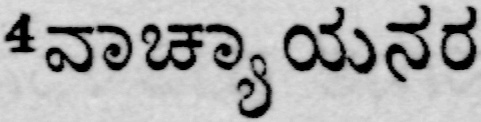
4ವಾಚ್ಯಾಯನರ
